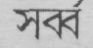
সৰ্ব্ব
